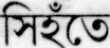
সিহঁতে
